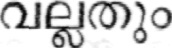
വല്ലതും
